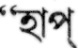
"হাপ্
